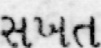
સખત
